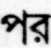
পর
